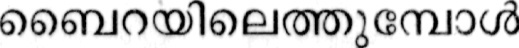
ബൈറയിലെത്തുമ്പോള്‍
